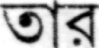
তার
